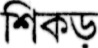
শিকড়
